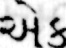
એક
